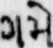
ગમે
